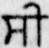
ਸੀ
